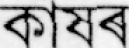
কাষৰ
